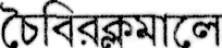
চৈবিরক্লমালে
